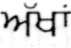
ਅੱਖਾਂ
